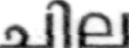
ചില
